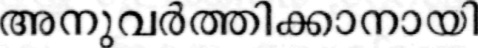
അനുവര്‍ത്തിക്കാനായി
